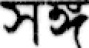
সঙ্গ
